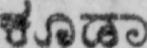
ಕೂಡಾ
